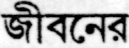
জীবনের
